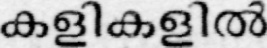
കളികളില്‍
